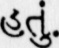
હતું.
